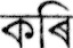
কৰি
